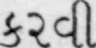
કરવી
